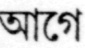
আগে
